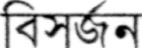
বিসর্জন
